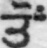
ਤੋਂ
